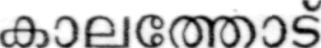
കാലത്തോട്
